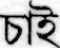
চাই
